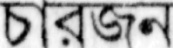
চারজন
